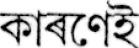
কাৰণেই
